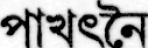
পাখৎনৈ
